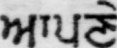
ਆਪਣੇ
